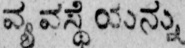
ವ್ಯವಸ್ಥೆಯನ್ನು
